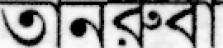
তানরুবা
